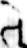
તે
